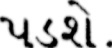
પડશે.
